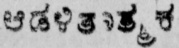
ಆಡಳಿತಾತ್ಮಕ
